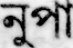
নুপা
